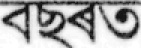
বছৰত
